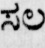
ಸಲ
